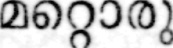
മറ്റൊരു
